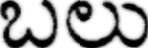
ಬಲು
